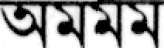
অমমম
